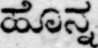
ಹೊನ್ನ
